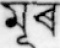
মূৰ
